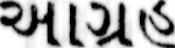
આગ્રહ
